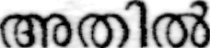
അതില്‍
